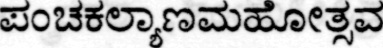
ಪಂಚಕಲ್ಯಾಣಮಹೋತ್ಸವ
